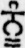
ਨੂੰ
